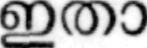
ഇതാ
